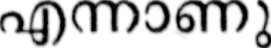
എന്നാണു
